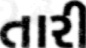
તારી
